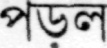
পড়ল
